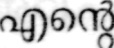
എന്റെ
